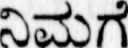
ನಿಮಗೆ
